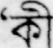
‘কী
